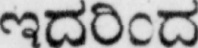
ಇದರಿಂದ
